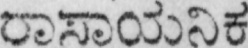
ರಾಸಾಯನಿಕ
